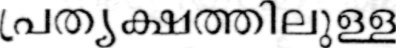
പ്രത്യക്ഷത്തിലുള്ള
